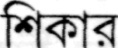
শিকার
